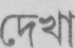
দেখা
